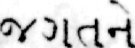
જગતને
